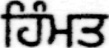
ਹਿੰਮਤ
